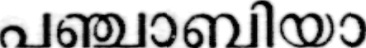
പഞ്ചാബിയാ
